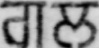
ਗਲ
